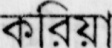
করিয়া
